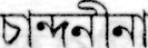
চান্দনীনা
